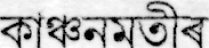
কাঞ্চনমতীৰ
